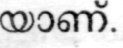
യാണ്.
